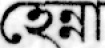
হেন্না
